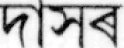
দাসৰ
